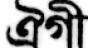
ঐগী
